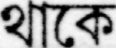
থাকে
